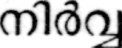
നിര്‍വ്വ
